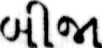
બીજા
